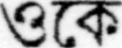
ওকে
